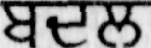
ਬਦਲ
